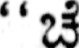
"ಚೆ
